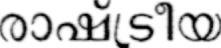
രാഷ്ട്രീയ
